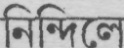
নিন্দিলে
